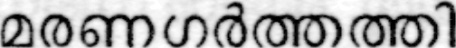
മരണഗര്‍ത്തത്തി
